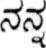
ನನ್ನ
